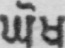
ਘੋਖ
